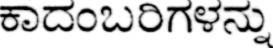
ಕಾದಂಬರಿಗಳನ್ನು
